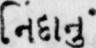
નિંદાનું
